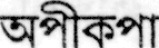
অপীকপা
